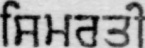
ਸਿਮਤਰੀ
